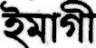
ইমাগী
